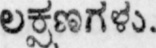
ಲಕ್ಷಣಗಳು.
